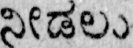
ನೀಡಲು
